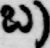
ಬ)
